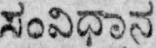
ಸಂವಿಧಾನ
